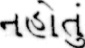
નહોતું
